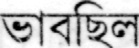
ভাবছিল
